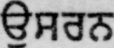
ਉਸਰਨ
